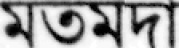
মতমদা
